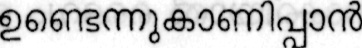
ഉണ്ടെന്നുകാണിപ്പാന്‍
